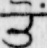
ਤੋਂ
